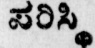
ಪರಿಸ್ಥಿ
